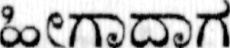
ಹೀಗಾದಾಗ
